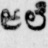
ಅಲೆ
